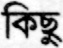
কিছু
